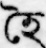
হৈ
